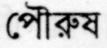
পৌরুষ
